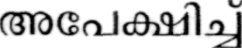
അപേക്ഷിച്ച്
